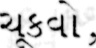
ચૂકવો,
